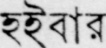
হইবার
